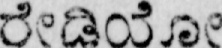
ರೇಡಿಯೋ
